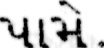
પામે.
